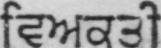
ਵਿਅਕਤੀ
